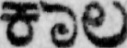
ಕಾಲ
